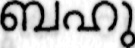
ബഹു
